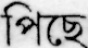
পিছে
